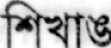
শিখাঙ
